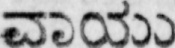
ವಾಯು
